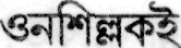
ওনশিল্লকই
